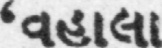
'વહાલા
